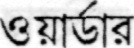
ওয়ার্ডার
